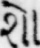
શો
